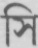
সি
